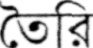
তৈরি
